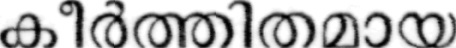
കീര്‍ത്തിതമായ
